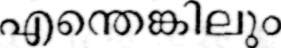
എന്തെങ്കിലും
